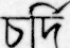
চর্দি
